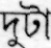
দুটা
